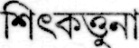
শিৎকত্তুনা
